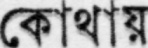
কোথায়
